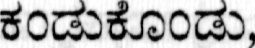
ಕಂಡುಕೊಂಡು,
